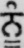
ਨੂੰ
